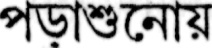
পড়াশুনোয়
